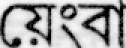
য়েংবা
